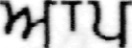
ਆਪ
